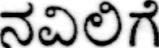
ನವಿಲಿಗೆ
